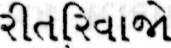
રીતરિવાજો
